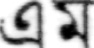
এম
